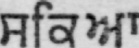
ਸਕਿਆ
